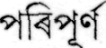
পৰিপূৰ্ণ
